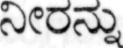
ನೀರನ್ನು
